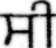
ਸੀ
